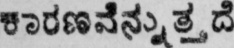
ಕಾರಣವೆನ್ನುತ್ತದೆ
